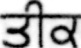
ਤੀਕ
